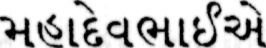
મહાદેવભાઈએ
